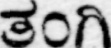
ತಂಗಿ
